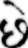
છે
